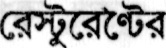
রেস্টুরেণ্টের
